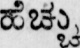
ಹೆಚ್ಚು
